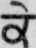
ਕੇ
